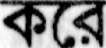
করে
